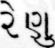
રેણુ
